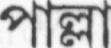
পাল্লা
